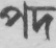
পদ
